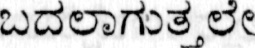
ಬದಲಾಗುತ್ತಲೇ
